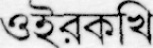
ওইরকখি
